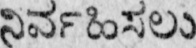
ನಿರ್ವಹಿಸಲು
